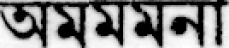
অমমমনা
